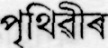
পৃথিৱীৰ
